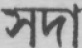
সদা
